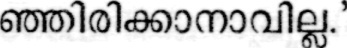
ഞ്ഞിരിക്കാനാവില്ല.’
